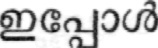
ഇപ്പോള്‍
